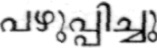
പഴുപ്പിച്ചു
